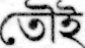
তৌই
